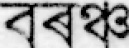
বৰঞ্চ
